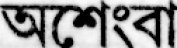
অশেংবা
